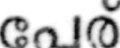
പേര്
